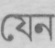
যেন
